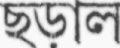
ছড়াল
